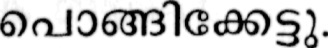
പൊങ്ങിക്കേട്ടു.
